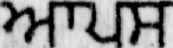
ਆਪਸ
